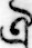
ঐ
